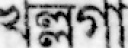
খল্লগা
